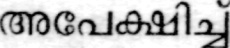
അപേക്ഷിച്ച്
